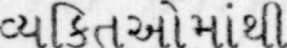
વ્યક્તિઓમાંથી
